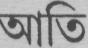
আতি
